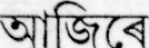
আজিৰে
